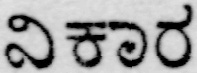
ವಿಕಾರ
